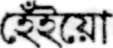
হেঁইয়ো
